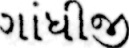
ગાંધીજી
